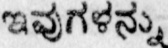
ಇವುಗಳನ್ನು
